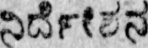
ನಿರ್ದೇಶನ
